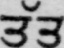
ਤੱਤ
